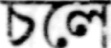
চলে
